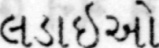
લડાઈઓ
